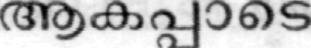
ആകപ്പാടെ
